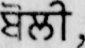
ਬੋਲੀ,
